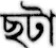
ছটা
